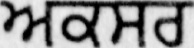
ਅਕਸਰ
